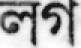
লগ
